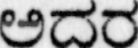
ಅದರ
